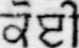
ਕੋਈ
